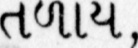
તળાય,
